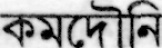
কমদৌনি
